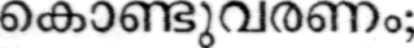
കൊണ്ടുവരണം;
